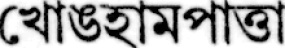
খোঙহামপাত্তা
